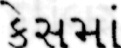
કેસમાં
